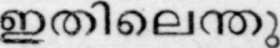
ഇതിലെന്തു
